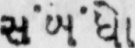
સંબંધો
